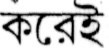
করেই
